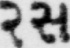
રસ
